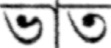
ভাত
